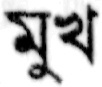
মুখ
